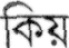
কিয়
